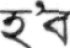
হ'ব
